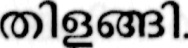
തിളങ്ങി.
